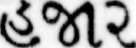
હજાર
